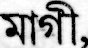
মাগী,
